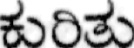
ಕುರಿತು
